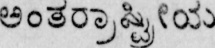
ಅಂತರ್ರಾಷ್ಟ್ರೀಯ
